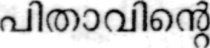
പിതാവിന്റെ
